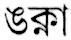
ঙক্না
